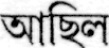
আছিল
